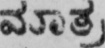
ಮಾತ್ರ
